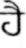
ਹੈ
